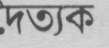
দৈত্যক
